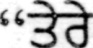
''ਤੇਰੇ
